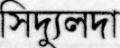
সিদ্যুলদা
